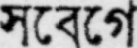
সবেগে
